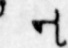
ન
